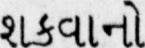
શકવાનો
